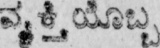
ವ್ಯಕ್ತಿಯೊಬ್ಬ
